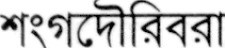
শংগদৌরিবরা
